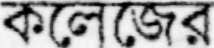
কলেজের
